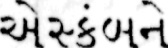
એસ્કંબને
